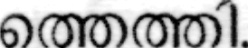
ത്തെത്തി.
